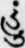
હું
